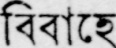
বিবাহে
